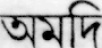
অমদি
